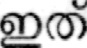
ഇത്
